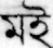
মই
